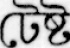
টেষ্ট
